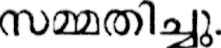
സമ്മതിച്ചു.
